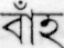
বাঁহ
